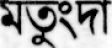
মতুংদা
